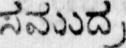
ಸಮುದ್ರ
